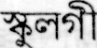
স্কুলগী
